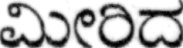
ಮೀರಿದ
